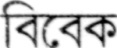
বিবেক
